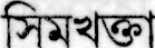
সিমখক্তা
